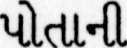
પોતાની
